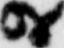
જ
